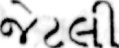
જેટલી
